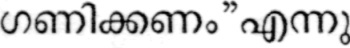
ഗണിക്കണം”എന്നു
